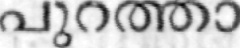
പുറത്താ
